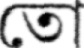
তো
